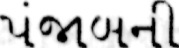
પંજાબની
